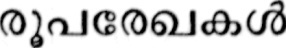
രൂപരേഖകള്‍
